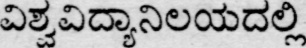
ವಿಶ್ವವಿದ್ಯಾನಿಲಯದಲ್ಲಿ
